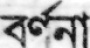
বৰ্ণনা
